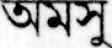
অমাসু
